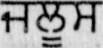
ਜਲੂਸ
